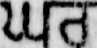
ਘਰ
